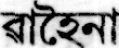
ৱাহৈনা
